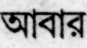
আবার
